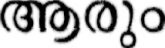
ആരും
